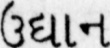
ઉદ્યાન
